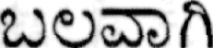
ಬಲವಾಗಿ
